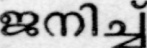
ജനിച്ച്
